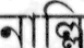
নাল্লি
